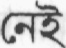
নেই
